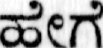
ಹೇಗೆ
